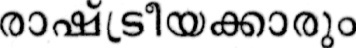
രാഷ്ട്രീയക്കാരും
